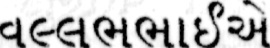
વલ્લભભાઈએ
